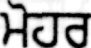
ਮੋਹਰ
